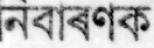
নিবাৰণক
